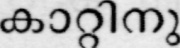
കാറ്റിനു
